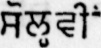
ਸੋਲ੍ਹਵੀਂ
